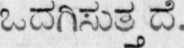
ಒದಗಿಸುತ್ತದೆ.
